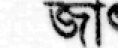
জা
